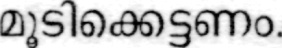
മൂടിക്കെട്ടണം.
